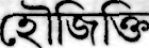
হৌজিক্তি
